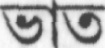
ভাত
